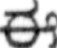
ಈ
